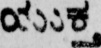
ಯುಕ್ತ
